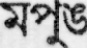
মপুঙ
